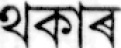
থকাৰ
